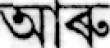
আৰু
